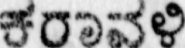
ಕರಾವಳಿ
